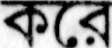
করে
